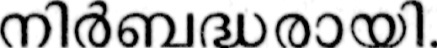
നിര്‍ബദ്ധരായി.
